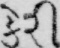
કેરી
